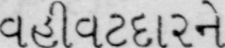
વહીવટદારને
